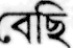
বেছি
